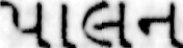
પાલન
